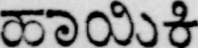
ಹಾಯಿಕಿ
